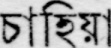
চাহিয়া
